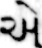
એ
